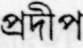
প্রদীপ
